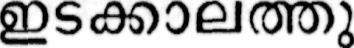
ഇടക്കാലത്തു
